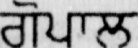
ਗੋਪਾਲ
